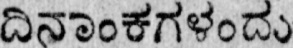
ದಿನಾಂಕಗಳಂದು
